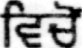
ਵਿਚੋਂ
